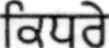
ਕਿਧਰੇ
